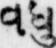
વધુ
